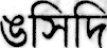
ঙসিদি
